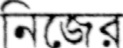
নিজের
